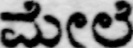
ಮೇಲೆ
